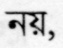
নয়,
